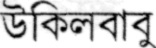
উকিলবাবু
